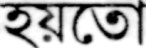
হয়তো
